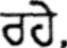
ਰਹੇ,
